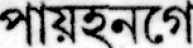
পায়হনগে
